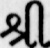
શ્રી
